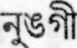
নুঙগী
